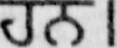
ਹਨ।
